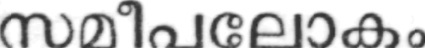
സമീപലോകം
